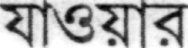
যাওয়ার
